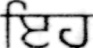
ਇਹ
